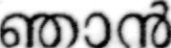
ഞാന്‍
